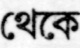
থেকে
